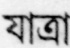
যাত্রা
